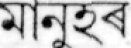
মানুহৰ
